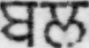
ਬਲ
